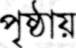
পৃষ্ঠায়
